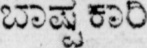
ಬಾಷ್ಪಕಾರಿ
